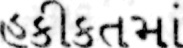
હકીકતમાં
